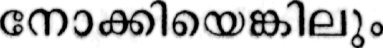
നോക്കിയെങ്കിലും
